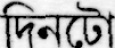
দিনটো
